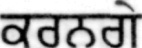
ਕਰਨਗੇ
